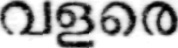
വളരെ
